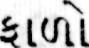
ફાળો
